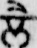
ਲੈ
